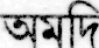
অমদি
